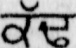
ਕੱਢ
